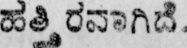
ಹತ್ತಿರವಾಗಿದೆ.
